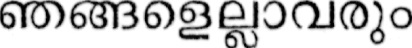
ഞങ്ങളെല്ലാവരും
